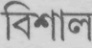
বিশাল
